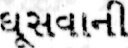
ઘૂસવાની
